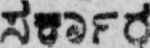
ಸರ್ಕಾರ
